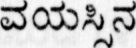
ವಯಸ್ಸಿನ
